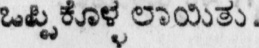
ಒಪ್ಪಿಕೊಳ್ಳಲಾಯಿತು.
